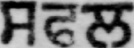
ਸਫਲ
